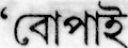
'বোপাই
